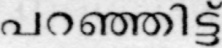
പറഞ്ഞിട്ട്
